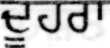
ਦੂਹਰਾ
